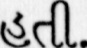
હતી.
